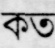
কত
